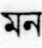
মন
